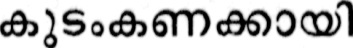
കുടംകണക്കായി
